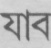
যাব
